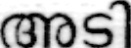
അടി
